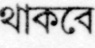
থাকবে
